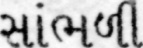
સાંભળી
